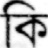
কি
